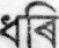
ধৰি
